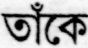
তাঁকে
